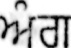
ਅੰਗ
